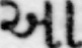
આ
